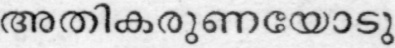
അതികരുണയോടു
